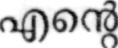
എന്റെ
